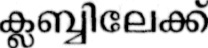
ക്ലബ്ബിലേക്ക്
